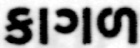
કાગળ
